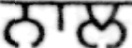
ਨਾਲ
